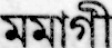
মমাগী
